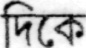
দিকে
